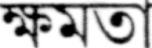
ক্ষমতা
